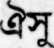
ঐসু
